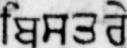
ਬਿਸਤਰੇ
